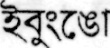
ইবুংঙো
